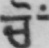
ਚੋਂ
